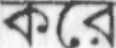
করে
